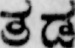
ತಡ
